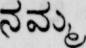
ನಮ್ಮ
